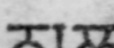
ਨਾਲ
